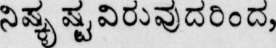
ನಿಷ್ಕೃಷ್ಟವಿರುವುದರಿಂದ,
